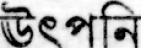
ঊৎপনি
